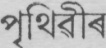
পৃথিৱীৰ
